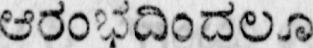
ಆರಂಭದಿಂದಲೂ
